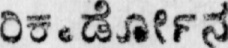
ರಿಕಾರ್ಡೋನ
